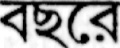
বছরে
